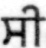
ਸੀ
